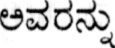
ಅವರನ್ನು
